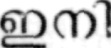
ഇനി
